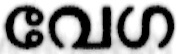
വേഗ
